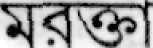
মরক্তা
